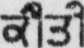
ਕੀਤੀ
